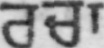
ਰਚਾ
